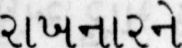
રાખનારને
